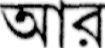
আর
